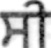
ਸੀ
